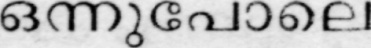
ഒന്നുപോലെ
